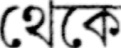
থেকে
